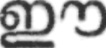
ഈ
